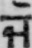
ਜੋ
